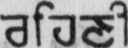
ਰਹਿਣੀ
